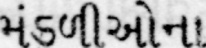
મંડળીઓના
